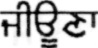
ਜੀਊਣਾ
